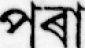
পৰা
